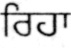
ਰਿਹਾ
